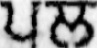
ਪਲ
